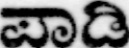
ಪಾಡಿ
